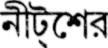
নীট্‌শের
